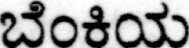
ಬೆಂಕಿಯ
